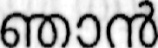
ഞാന്‍
